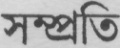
সম্প্ৰতি
